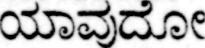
ಯಾವುದೋ
